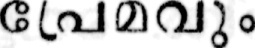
പ്രേമവും
